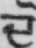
ਦੋ
